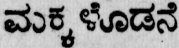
ಮಕ್ಕಳೊಡನೆ
